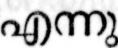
എന്നു
